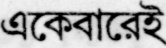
একেবারেই
